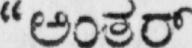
“ಅಂತರ್
